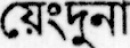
য়েংদুনা
